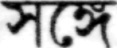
সঙ্গে
